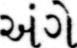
અંગે
